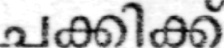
ചക്കിക്ക്
